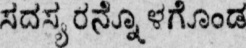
ಸದಸ್ಯರನ್ನೊಳಗೊಂಡ
